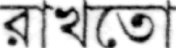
রাখতো
